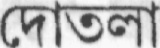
দোতলা
